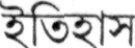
ইতিহাস
